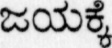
ಜಯಕ್ಕೆ
